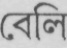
বেলি
